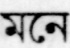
মনে
